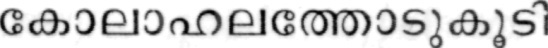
കോലാഹലത്തോടുകൂടി
